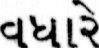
વધારે
